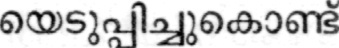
യെടുപ്പിച്ചുകൊണ്ട്
